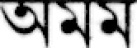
অমম
